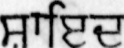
ਸ਼ਾਇਦ
